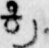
ಕ್ರಿ.
